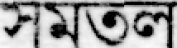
সমতল
